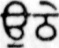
ਉਠੇ
